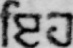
ਇਹ
